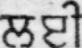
ਲਈ
